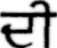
ਦੀ
